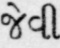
જેવી
